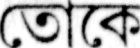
তোকে
